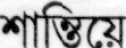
শান্তিয়ে
